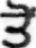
ਤੋਂ
